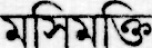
মসিমক্তি
